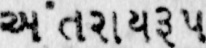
અંતરાયરૂપ
